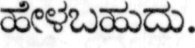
ಹೇಳಬಹುದು.
